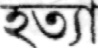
হত্যা
